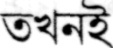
তখনই
